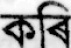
কৰি
